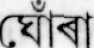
ঘোঁৰা
